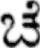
ಚೆ
